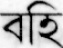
বহি
